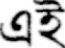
এই
